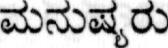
ಮನುಷ್ಯರು
